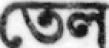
তেল
